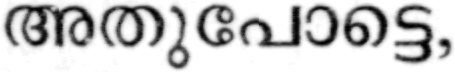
അതുപോട്ടെ,
